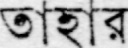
তাহার
